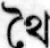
থৈ
